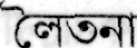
লৈতনা
